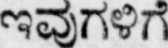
ಇವುಗಳಿಗೆ
